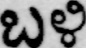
ಬಳಿ
